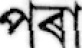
পৰা
